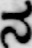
ನ
